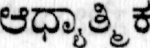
ಆಧ್ಯಾತ್ಮಿಕ
